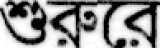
শুরুরে
